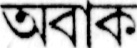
অবাক
